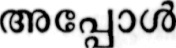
അപ്പോള്‍
